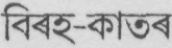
বিৰহ-কাতৰ
